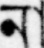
না
